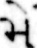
મેં
